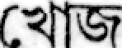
খোজ
